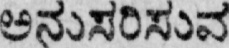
ಅನುಸರಿಸುವ
